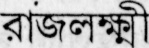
রাজলক্ষ্মী
